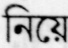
নিয়ে
